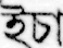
ইচা
